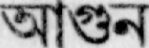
আগুন
